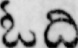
ಓದಿ
